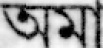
অমা
